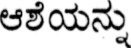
ಆಶೆಯನ್ನು
